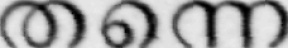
തന്നെ
